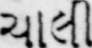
ચાલી
